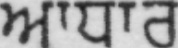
ਆਧਾਰ
